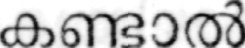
കണ്ടാല്‍
